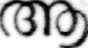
ആ
